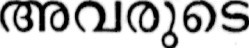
അവരുടെ
